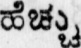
ಹೆಚ್ಚು
